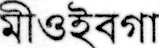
মীওইবগা
